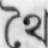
থৈ
